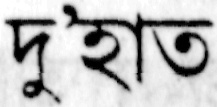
দু'হাত
